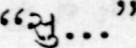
"સુ..."
